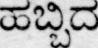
ಹಬ್ಬಿದ
